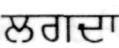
ਲਗਦਾ
